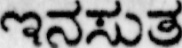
ಇನಸುತ
